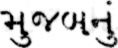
મુજબનું
